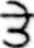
ਤੇ
